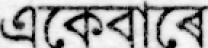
একেবাৰে
